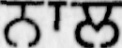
ਨਾਲ
